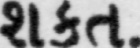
શકત.
